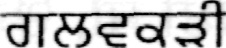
ਗਲਵਕੜੀ
